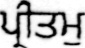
ਪ੍ਰੀਤਮੁ
